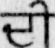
ਦੀ
